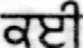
ਕਈ
